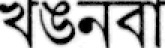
খঙনবা
